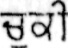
ਚੁਕੀ
